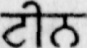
ਟੀਨ
